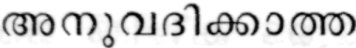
അനുവദിക്കാത്ത
